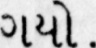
ગયો.
